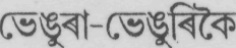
ভেঙুৰা-ভেঙুৰিকৈ
